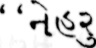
"નેહરુ
